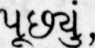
પૂછ્યું,
